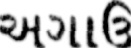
અગાઉ
